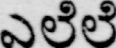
ಎಲೆಲೆ
